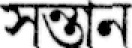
সন্তান
